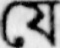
যে
